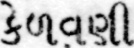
કેળવણી
